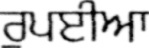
ਰੁਪਈਆ
